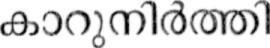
കാറുനിര്‍ത്തി
